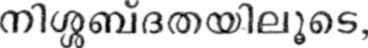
നിശ്ശബ്ദതയിലൂടെ,
